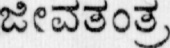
ಜೀವತಂತ್ರ
